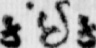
છે
